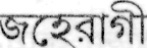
জহেরাগী
